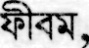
ফীবম,
